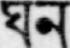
ঘন
